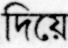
দিয়ে
